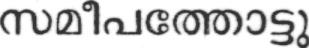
സമീപത്തോട്ടു
